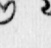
હજી
